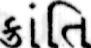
ક્રાંતિ
